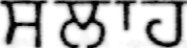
ਸਲਾਹ
